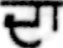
ਦਾ
